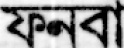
ফনবা
